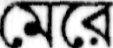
মেরে
